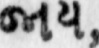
જાય,
